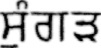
ਸੁੰਗੜ
